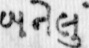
બનેલું
